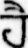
ਹੈ
